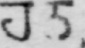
ਹਨ,
